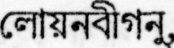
লোয়নবীগনু,
